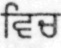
ਵਿਚ
